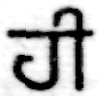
ਹੀ
